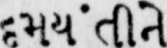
દમયંતીને
